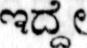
ಇದ್ದೇ
